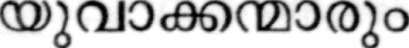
യുവാക്കന്മാരും
